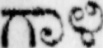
ಗಾಳಿ
